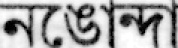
নঙোন্দা
